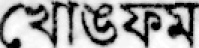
খোঙফম
